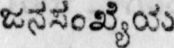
ಜನಸಂಖ್ಯೆಯ
